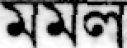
মমল
